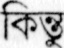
কিন্তু
